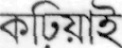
কঢ়িয়াই
